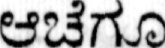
ಆಚೆಗೂ
